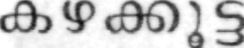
കഴക്കൂട്ട
